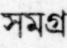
সমগ্র
